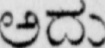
ಅದು
